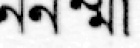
ননম্মা
